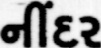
નીંદર
